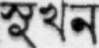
সুখন
